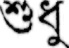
শুধু
